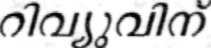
റിവ്യുവിന്
